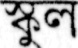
স্কুল
